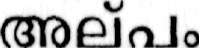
അല്പം
